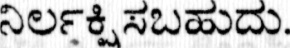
ನಿರ್ಲಕ್ಷಿಸಬಹುದು.
